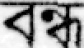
বন্ধ
